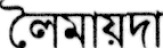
লৈমায়দা
